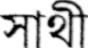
সাথী
